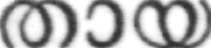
തായ
